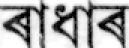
ৰাধাৰ
